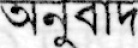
অনুবাদ
